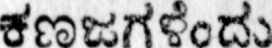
ಕಣಜಗಳೆಂದು
